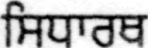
ਸਿਧਾਰਥ
